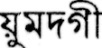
য়ুমদগী
